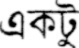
একটু
